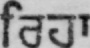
ਰਿਹਾ
